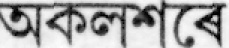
অকলশৰে
